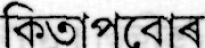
কিতাপবোৰ
